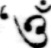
‘ওঁ
